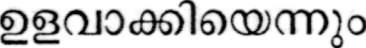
ഉളവാക്കിയെന്നും
